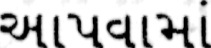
આપવામાં
